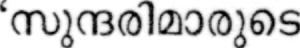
‘സുന്ദരിമാരുടെ
